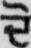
ਦੋ
